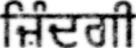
ਜ਼ਿੰਦਗੀ
